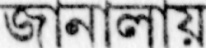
জানালায়
